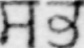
ਸਭ
